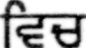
ਵਿਚ
